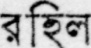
রহিল
